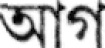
আগ
